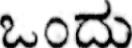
ಒಂದು
